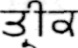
ਤ੍ਰੀਕ
